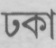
ঢকা
